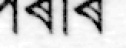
পৰাৰ
